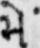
મેં
